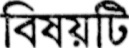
বিষয়টি
